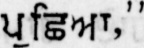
ਪੁਛਿਆ,''
